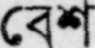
বেশ
